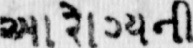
આરોગ્યની
